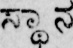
ಸ್ಥಾನ
